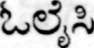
ಓಲೈಸಿ
